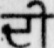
ਦੀ
